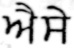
ਐਸੇ
